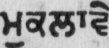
ਮੁਕਲਾਵੇ
